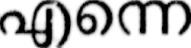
എന്നെ
